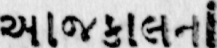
આજકાલનાં
